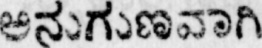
ಅನುಗುಣವಾಗಿ
